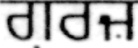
ਗ਼ਰਜ
